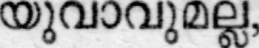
യുവാവുമല്ല,
